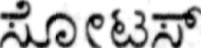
ಸೋಟಸ್
